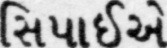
સિપાઈએ
